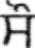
ਸੌ
